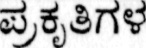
ಪ್ರಕೃತಿಗಳ
